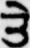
ਤੇ
